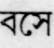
বসে
